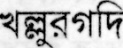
খল্লুরগদি
